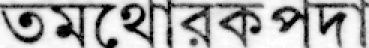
তমথোরকপদা
